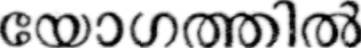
യോഗത്തില്‍
